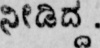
ನೀಡಿದ್ದ.
